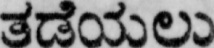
ತಡೆಯಲು
